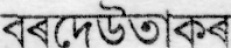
বৰদেউতাকৰ
